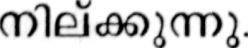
നില്ക്കുന്നു.
